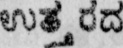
ಉತ್ತರದ
